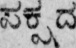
ಪಕ್ಷದ
